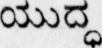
ಯುದ್ಧ
